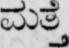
ಮತ್ತೆ
